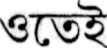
ওতেই
